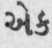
એક
